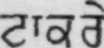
ਟਾਕਰੇ
